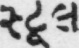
સ્ટૂલ
